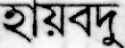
হায়বদু
